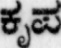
ಕೃಪ
